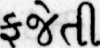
ફજેતી
